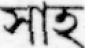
সাহ
